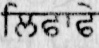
ਲਿਫਾਫੇ
